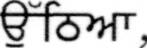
ਉੱਠਿਆ,
